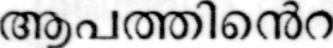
ആപത്തിന്റെ
